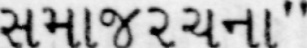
સમાજરચના"
